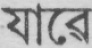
যাৱে
